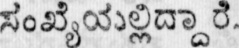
ಸಂಖ್ಯೆಯಲ್ಲಿದ್ದಾರೆ.
